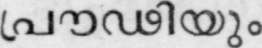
പ്രൌഢിയും
